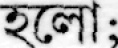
হলো;
